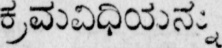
ಕ್ರಮವಿಧಿಯನ್ನು
